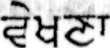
ਵੇਖਣਾ
